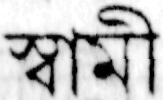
স্বামী
